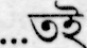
...তই
